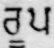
ਰੂਪ
